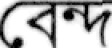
বেন্দ
